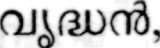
വൃദ്ധന്‍,
